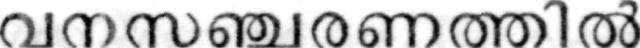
വനസഞ്ചരണത്തില്‍
